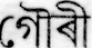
গৌৰী
